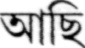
আছি
